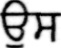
ਉਸ
